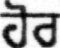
ਹੋਰ
